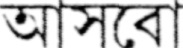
আসবো
